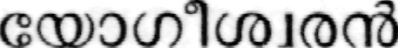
യോഗീശ്വരന്‍
